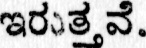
ಇರುತ್ತವೆ.
